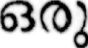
ഒരു
